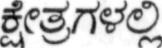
ಕ್ಷೇತ್ರಗಳಲ್ಲಿ
